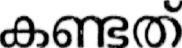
കണ്ടത്
